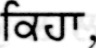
ਕਿਹਾ,
